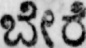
ಬೇರೆ
